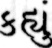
કહ્યું
